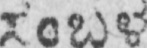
ಸಂಬಳ
